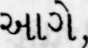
આગે,
